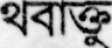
থবাক্তু
